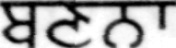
ਬਣਨਾ
